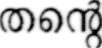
തന്റെ
